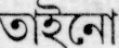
তাইনো
